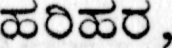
ಹರಿಹರ,
